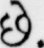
છે.
